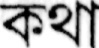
কথা
